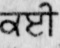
ਕਈ
